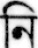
নি
